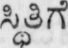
ಸ್ಥಿತಿಗೆ
